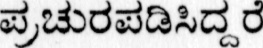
ಪ್ರಚುರಪಡಿಸಿದ್ದರೆ
